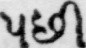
પછી
